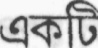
একটি
